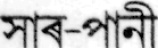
সাৰ-পানী
